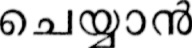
ചെയ്യാന്‍
